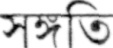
সঙ্গতি
